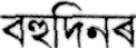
বহুদিনৰ
